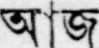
আজ
